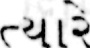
ત્યારે
